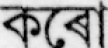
কৰো
